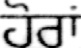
ਹੋਰਾਂ
